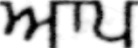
ਆਪ
